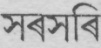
সৰসৰি
